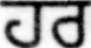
ਹਰ
